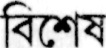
বিশেষ
